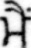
ਮੈਂ
